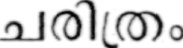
ചരിത്രം
